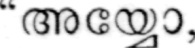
"അയ്യോ,
